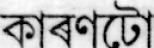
কাৰণটো
